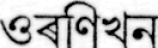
ওৰণিখন
